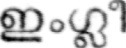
ഇംഗ്ലീ
